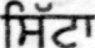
ਸਿੱਟਾ
